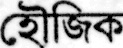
হৌজিক
